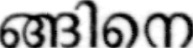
ങ്ങിനെ
